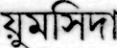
য়ুমসিদা
